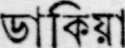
ডাকিয়া
